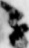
કે
